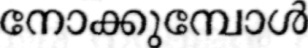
നോക്കുമ്പോള്‍
